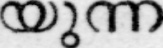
യുന്ന
